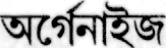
অর্গেনাইজ
